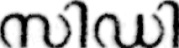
സിഡി
